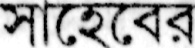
সাহেবের
